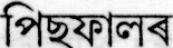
পিছফালৰ
